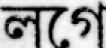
লগে
